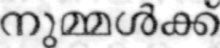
നുമ്മള്‍ക്ക്
